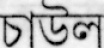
চাউল
